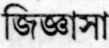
জিজ্ঞাসা
